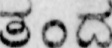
ತಂದ
